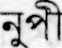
নুপী
